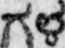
ಗಳ
